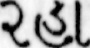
રહા
